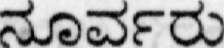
ನೂರ್ವರು
